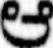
ಆ
